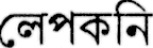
লেপকনি
